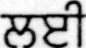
ਲਈ
